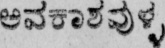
ಅವಕಾಶವುಳ್ಳ
